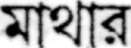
মাথার
